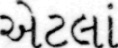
એટલાં
